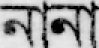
নানা
